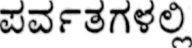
ಪರ್ವತಗಳಲ್ಲಿ
